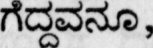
ಗೆದ್ದವನೂ,
